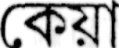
কেয়া
